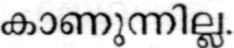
കാണുന്നില്ല.
